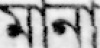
মানা
